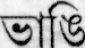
ভাঙি
